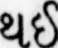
થઈ
